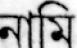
নামি
